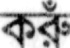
করুঁ
